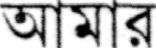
আমার
